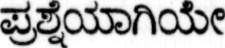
ಪ್ರಶ್ನೆಯಾಗಿಯೇ
